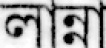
লান্না
